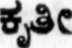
ಕೃತೀ
